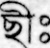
ছীঃ
